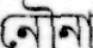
নৌনা
